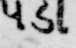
પડી
